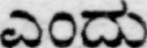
ಎಂದು
